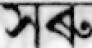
সৰু
